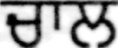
ਚਾਲ
